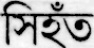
সিহঁত
